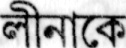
লীনাকে
